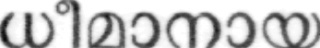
ധീമാനായ
